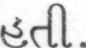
હતી.
